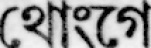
থোংগে
